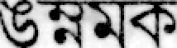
ঙম্নমক
